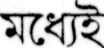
মধ্যেই
